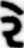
રે
